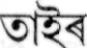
তাইৰ
